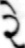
રે
